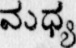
ಮಧ್ಯ
